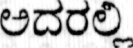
ಅದರಲ್ಲಿ
